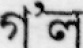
গ'ল
